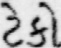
ટેકો
